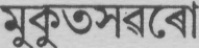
মুকুতসৱৰো
